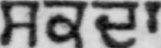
ਸਕਦਾ
